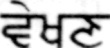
ਵੇਖਣ
